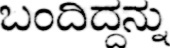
ಬಂದಿದ್ದನ್ನು
